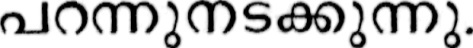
പറന്നുനടക്കുന്നു.
